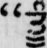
''ਤੂੰ
